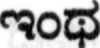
ಇಂಥ
